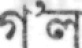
গ'ল
